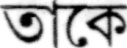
তাকে
